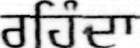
ਰਹਿੰਦਾ
